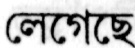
লেগেছে
